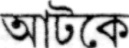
আটকে
